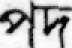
পদ
